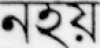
নহয়
